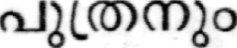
പുത്രനും
